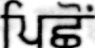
ਪਿਛੋਂ
